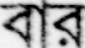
বার
